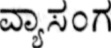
ವ್ಯಾಸಂಗ
